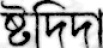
ষ্টদিদা
